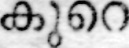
കുറെ
